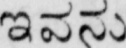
ಇವನು
